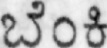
ಬೆಂಕಿ
